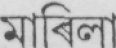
মাৰিলা
